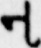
ન
